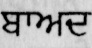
ਬਾਅਦ
